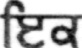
ਇਕ
